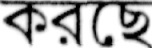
করছে
